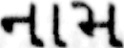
નામ
